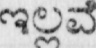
ಇಲ್ಲವೆ
